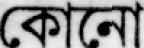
কোনো
